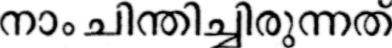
നാംചിന്തിച്ചിരുന്നത്
